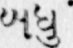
બધું
